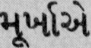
મૂર્ખાએ
